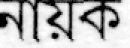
নায়ক
